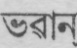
ভৱান্‌
